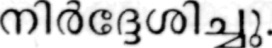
നിര്‍ദ്ദേശിച്ചു.
